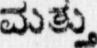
ಮತ್ತು
